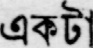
একটা
